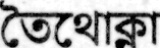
তৈথোক্না
